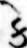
કે
